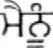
ਮੈਨੂੰ
